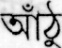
আঁঠু
